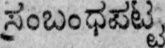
ಸಂಬಂಧಪಟ್ಟ
